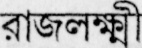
রাজলক্ষ্মী
